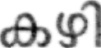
കഴി
